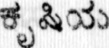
ಕೃಷಿಯ
